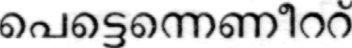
പെട്ടെന്നെണീററ്
